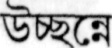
উচ্ছন্নে
